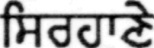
ਸਿਰਹਾਣੇ
